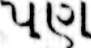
પણ
